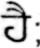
ਹੈ;
